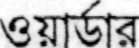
ওয়ার্ডার
